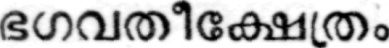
ഭഗവതീക്ഷേത്രം
